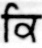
ਕਿ
